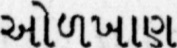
ઓળખાણ
